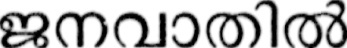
ജനവാതില്‍
